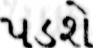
પડશે
